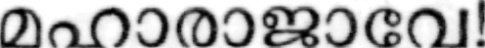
മഹാരാജാവേ!
